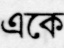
একে
